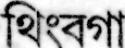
থিংবগা
